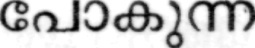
പോകുന്ന
